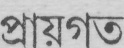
প্ৰায়গত
